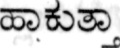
ಹಾಕುತ್ತಾ
